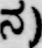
ನ)
